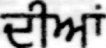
ਦੀਆਂ
